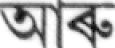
আৰু
